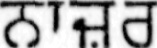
ਨਾਜ਼ਰ
